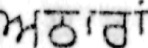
ਅਠਾਰਾਂ
